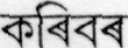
কৰিবৰ
